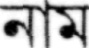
নাম
